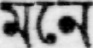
মনে
